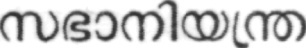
സഭാനിയന്ത്ര
